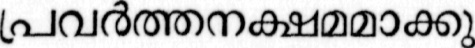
പ്രവര്‍ത്തനക്ഷമമാക്കു
